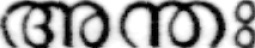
അന്തഃ
